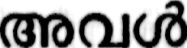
അവള്‍
